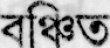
বঞ্চিত
